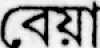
বেয়া
